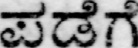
ಪಡೆಗೆ
